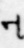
ન
